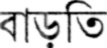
বাড়তি
